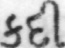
કદી
